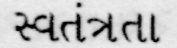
સ્વતંત્રતા
